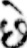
છે
